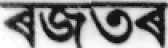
ৰজতৰ
